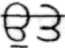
ਉਤੇ
